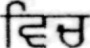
ਵਿਚ
